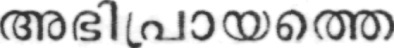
അഭിപ്രായത്തെ
